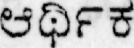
ಆರ್ಥಿಕ
